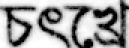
চৎখ্রে
